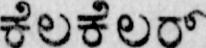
ಕೆಲಕೆಲರ್
